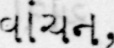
વાંચન,
